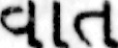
વાત
